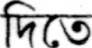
দিতে
